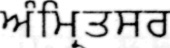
ਅੰਮ੍ਰਿਤਸਰ
